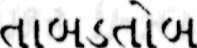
તાબડતોબ
